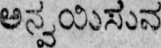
ಅನ್ವಯಿಸುವ
